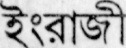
ইংরাজী
